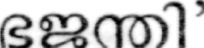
ഭജന്തി'
